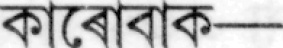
কাৰোবাক-
